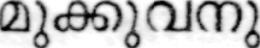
മുക്കുവനു
